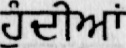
ਹੁੰਦੀਆਂ
